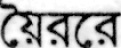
য়ৈররে
